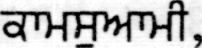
ਕਾਮਸੁਆਮੀ,
